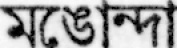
মঙোন্দা
